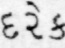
દરેક
